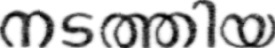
നടത്തിയ
